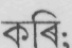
কৰি;
